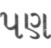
પણ
